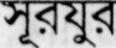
সূরযুর
